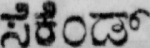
ಸೆಕೆಂಡ್
